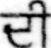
ਦੀ
